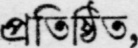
প্রতিষ্ঠিত,
